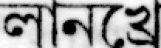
লানখ্রে
